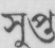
সুপ্ত
